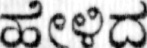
ಹೇಳಿದ
